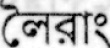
লৈরাং
